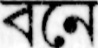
বনে
